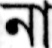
না
